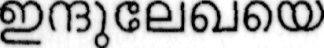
ഇന്ദുലേഖയെ
